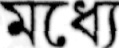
মধ্যে
